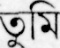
তুমি
